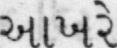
આખરે
